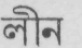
লীন
